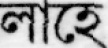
লাহে
